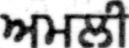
ਅਮਲੀ
